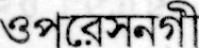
ওপরেসনগী
